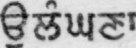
ਉਲੰਘਣਾ
